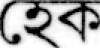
হেক
